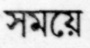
সময়ে
